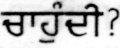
ਚਾਹੁੰਦੀ?
